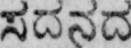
ಸದನದ
